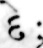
દે;
